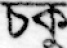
চকু
